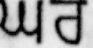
ਘਰ
